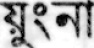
য়ুংনা
